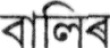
বালিৰ
